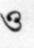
ও
